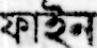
ফাইন
